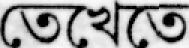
তেখেতে
